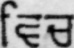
ਵਿਚ
